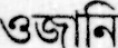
ওজানি
